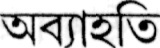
অব্যাহতি
